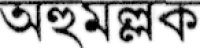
অহুমল্লক
